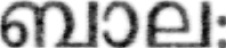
ബാല:
